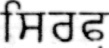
ਸਿਰਫ਼
